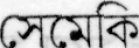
সেমেকি
